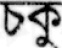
চকু
